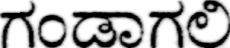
ಗಂಡಾಗಲಿ
